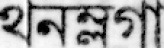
থনম্লগা
